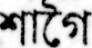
শাগৈ
